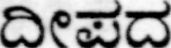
ದೀಪದ
